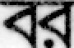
বর
